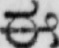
ಈ
